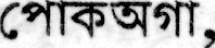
পোকঅগা,
